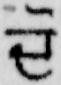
ਦੋ
